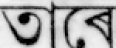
তাৰে
